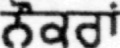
ਨੌਕਰਾਂ
